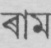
ৰাম
